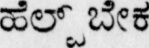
ಹೆಲ್ಪ್‌ಬೇಕ
